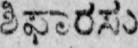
ಶಿಫಾರಸು
